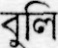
বুলি
